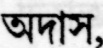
অদাস,
